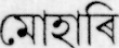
মোহাৰি
